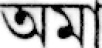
অমা
